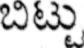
ಬಿಟ್ಟು
